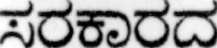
ಸರಕಾರದ
